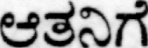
ಆತನಿಗೆ
